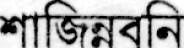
শাজিন্নবনি
